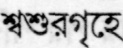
শ্বশুরগৃহে
